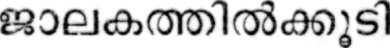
ജാലകത്തില്‍ക്കൂടി
